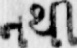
નથી
